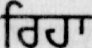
ਰਿਹਾ
